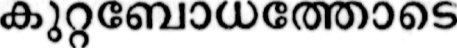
കുറ്റബോധത്തോടെ
